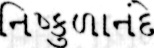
નિષ્કુળાનંદે
